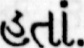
હતાં.
